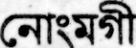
নোংমগী
